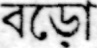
বড়ো
